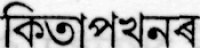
কিতাপখনৰ
